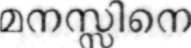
മനസ്സിനെ
